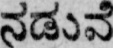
ನಡುವೆ
